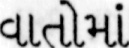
વાતોમાં
